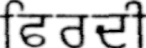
ਫਿਰਦੀ
